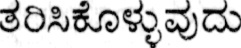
ತರಿಸಿಕೊಳ್ಳುವುದು
